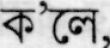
ক'লে,
